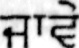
ਜਾਵੇ
